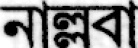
নাল্লবা
